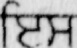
ਇਸ
